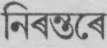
নিৰন্তৰে
